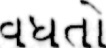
વધતો
